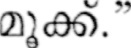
മൂക്ക്.”
